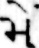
મેં
